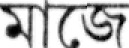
মাজে
